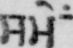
ਸਮੇਂ
